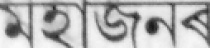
মহাজনৰ
